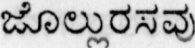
ಜೊಲ್ಲುರಸವು
